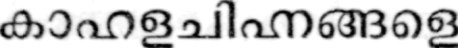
കാഹളചിഹ്നങ്ങളെ
